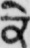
ਕੇ
